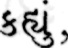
કહ્યું,
